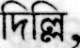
দিল্লি,
